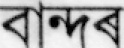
বান্দৰ
